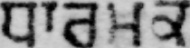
ਧਾਰਮਕ
